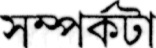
সম্পর্কটা
